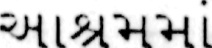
આશ્રમમાં
